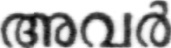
അവര്‍
